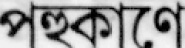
পহুকাণে
